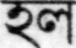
হল
